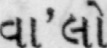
વા'લો
